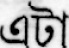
এটা
